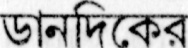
ডানদিকের
